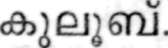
കുലൂബ്.
